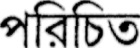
পরিচিত
